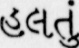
હલતું
